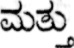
ಮತ್ತು
